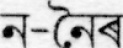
ন-নৈৰ
